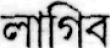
লাগিব
